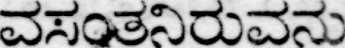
ವಸಂತನಿರುವನು
